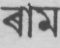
ৰাম
